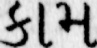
કામ
